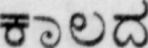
ಕಾಲದ
